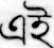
এই
